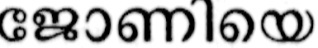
ജോണിയെ
